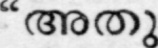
"അതു
